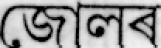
জোলৰ
